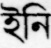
ইনি
